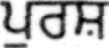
ਪੁਰਸ਼
